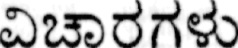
ವಿಚಾರಗಳು
